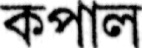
কপাল
